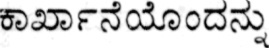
ಕಾರ್ಖಾನೆಯೊಂದನ್ನು
